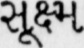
સૂક્ષ્મ
